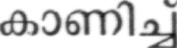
കാണിച്ച്
